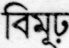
বিমূঢ়
